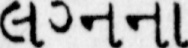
લગ્નના
